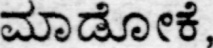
ಮಾಡೋಕೆ,
